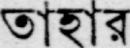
তাহার
